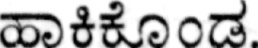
ಹಾಕಿಕೊಂಡ.
